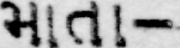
માતા-
